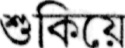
শুকিয়ে
